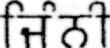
ਜਿੰਨੀ
